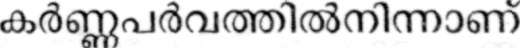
കര്‍ണ്ണപര്‍വത്തില്‍നിന്നാണ്
